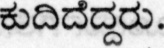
ಕುದಿದೆದ್ದರು.
